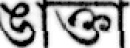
ঙাক্তা
